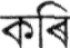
কৰি
